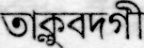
তাক্লুবদগী
